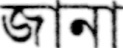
জানা
